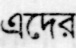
এদের
